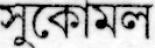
সুকোমল
